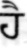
ਹੈ
